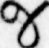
જ
